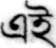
এই
